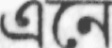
এনে
